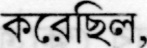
করেছিল,
